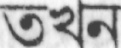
তখন
